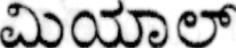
ಮಿಯಾಲ್
